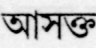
আসক্ত
